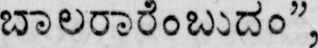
ಬಾಲರಾರೆಂಬುದಂ”,
